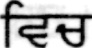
ਵਿਚ
